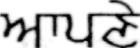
ਆਪਣੇ
